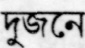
দুজনে
